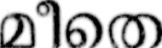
മീതെ
